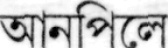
আনপিলে
